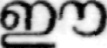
ഈ
